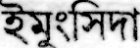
ইমুংসিদা
